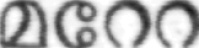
മറേറ
